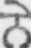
ਨੇ
